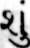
શું
